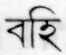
বহি
